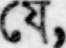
যে,
